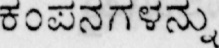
ಕಂಪನಗಳನ್ನು
